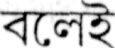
বলেই
